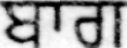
ਬਾਗ
